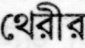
থেরীর
